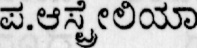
ಪ.ಆಸ್ಟ್ರೇಲಿಯಾ
